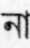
না
